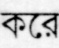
করে
